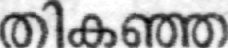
തികഞ്ഞ
